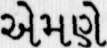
એમણે
